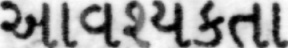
આવશ્યકતા
